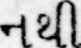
નથી
